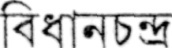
বিধানচন্দ্র
